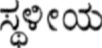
ಸ್ಥಳೀಯ
